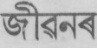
জীৱনৰ
